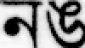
নঙ
